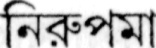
নিরুপমা
